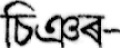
চিঞৰ-
